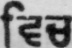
ਵਿਚ
